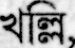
খল্লি,
